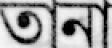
তানা
